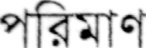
পরিমাণ
